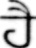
ਹੈ
